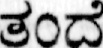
ತಂದೆ
